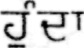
ਹੁੰਦਾ
